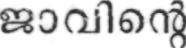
ജാവിന്റെ
